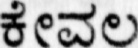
ಕೇವಲ
